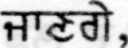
ਜਾਣਗੇ,
